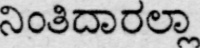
ನಿಂತಿದಾರಲ್ಲಾ
